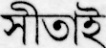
সীতাই
